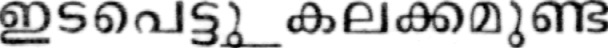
ഇടപെട്ടു_കലക്കമുണ്ട
